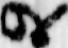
જ
